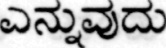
ಎನ್ನುವುದು
